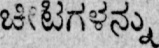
ಚೀಟಿಗಳನ್ನು
